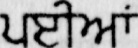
ਪਈਆਂ
